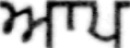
ਆਪ
